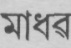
মাধৱ
